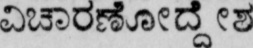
ವಿಚಾರಣೋದ್ದೇಶ
